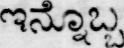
ಇನ್ನೊಬ್ಬ
